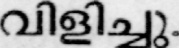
വിളിച്ചു.
